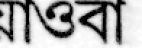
য়াওবা
